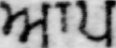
ਆਪ
